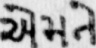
એમને
